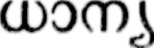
ധാന്യ
